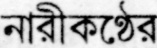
নারীকণ্ঠের
